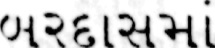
બરદાસમાં
